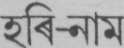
হৰি-নাম
